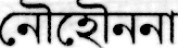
নৌহৌননা
